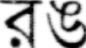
রঙ
